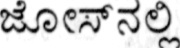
ಜೋಸ್ನಲ್ಲಿ
